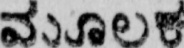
ಮೂಲಕ
